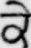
ਕੇ
